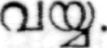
വയ്യ.
